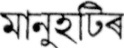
মানুহটিৰ
